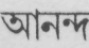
আনন্দ
